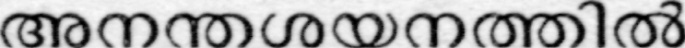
അനന്തശയനത്തില്‍
